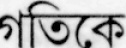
গতিকে
